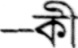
-কী
